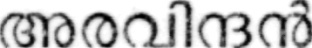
അരവിന്ദന്‍
